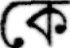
কে
